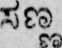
ಸಣ್ಣ
